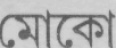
মোকো
